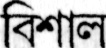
বিশাল
